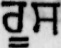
ਰੂਸ
